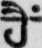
ਹੈਂ
